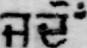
ਜਦੋਂ
